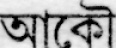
আকৌ
